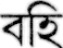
বহি
